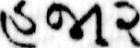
હજાર
